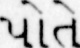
પોતે
